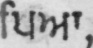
ਪਿਆ,
